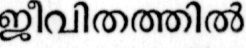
ജീവിതത്തില്‍
